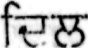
ਦਿਲ
